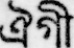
এগী
